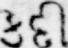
કદી
